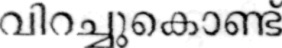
വിറച്ചുകൊണ്ട്
